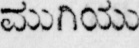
ಮುಗಿಯು
